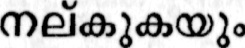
നല്കുകയും
